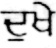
ਦੁਖੇ
